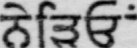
ਨੇੜਿਓਂ
